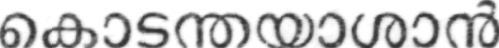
കൊടന്തയാശാന്‍
